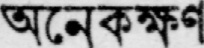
অনেকক্ষণ
